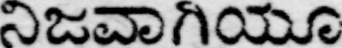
ನಿಜವಾಗಿಯೂ
